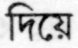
দিয়ে
